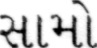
સામો
